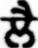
ਲੈ
